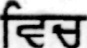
ਵਿਚ
